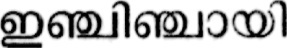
ഇഞ്ചിഞ്ചായി
